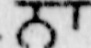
ਨਾ
